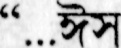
“...ঈস
